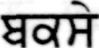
ਬਕਸੇ
